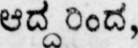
ಆದ್ದರಿಂದ,
